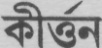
কীৰ্ত্তন
